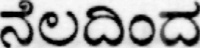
ನೆಲದಿಂದ
